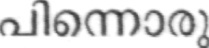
പിന്നൊരു
